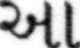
આ
